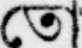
তো
